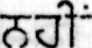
ਨਹੀਂ
